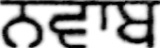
ਨਵਾਬ
